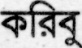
করিবু
